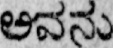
ಅವನು
